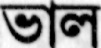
ভাল
